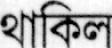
থাকিল
